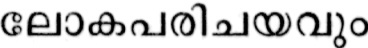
ലോകപരിചയവും
